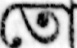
তো
